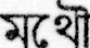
মথৌ
